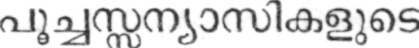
പൂച്ചസ്സന്യാസികളുടെ
